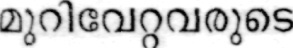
മൂറിവേറ്റവരുടെ
